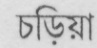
চড়িয়া
